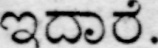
ಇದಾರೆ.
